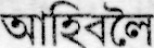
আহিবলৈ
